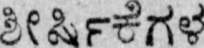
ಶೀರ್ಷಿಕೆಗಳ
